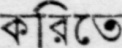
করিতে
